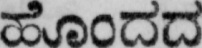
ಹೊಂದದ
